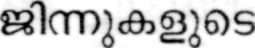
ജിന്നുകളുടെ
